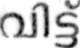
വിട്ട്
